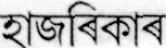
হাজৰিকাৰ
